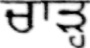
ਚਾੜ੍ਹ
